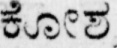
ಕೋಶ
